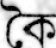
কৈ
